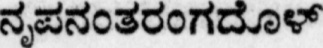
ನೃಪನಂತರಂಗದೊಳ್
